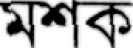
মশক
